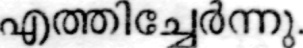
എത്തിച്ചേര്‍ന്നു.
